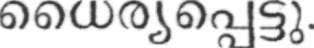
ധൈര്യപ്പെട്ടു.
